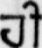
ਹੀ
